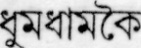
ধুমধামকৈ
